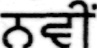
ਨਵੀ
